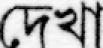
দেখা
